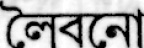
লৈবনো
